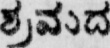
ಶ್ರಮದ
